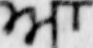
ਆ
